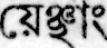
য়েঞ্ছাং
